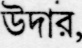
উদার,
